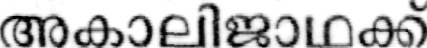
അകാലിജാഥക്ക്
